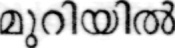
മുറിയില്‍
